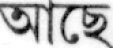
আছে
